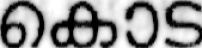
കൊട
